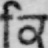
ਕਿ
